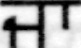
ਜਾ
